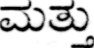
ಮತ್ತು
